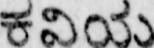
ಕವಿಯ
